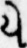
યે
